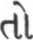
તો
